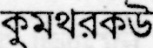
কুমথরকউ
